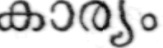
കാര്യം
